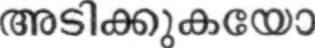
അടിക്കുകയോ
